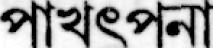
পাখৎপনা
